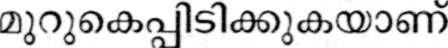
മുറുകെപ്പിടിക്കുകയാണ്
